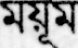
ময়ূম
